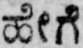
ಹೇಗೆ
